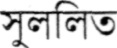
সুললিত
